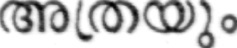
അത്രയും
